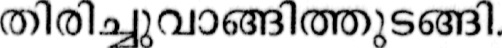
തിരിച്ചുവാങ്ങിത്തുടങ്ങി.
